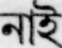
নাই
